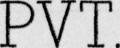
PVT.
